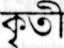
কৃতী
